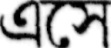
এসে
